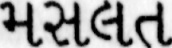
મસલત
